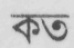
কত
